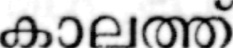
കാലത്ത്
